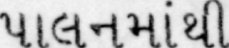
પાલનમાંથી
